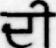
ਦੀ
